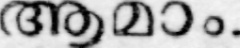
ആമാം.
